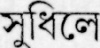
সুধিলে
